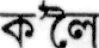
ক'লৈ
